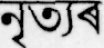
নৃত্যৰ
